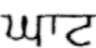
ਘਾਟ
